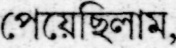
পেয়েছিলাম,
